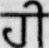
ਹੀ
